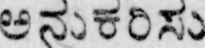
ಅನುಕರಿಸು
